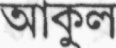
আকুল
